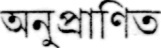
অনুপ্রাণিত
